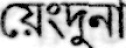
য়েংদুনা
